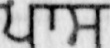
ਪਾਸ
